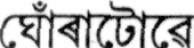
ঘোঁৰাটোৱে
